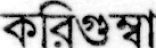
করিগুম্বা
